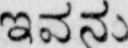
ಇವನು
